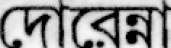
দোরেন্না
